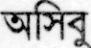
অসিবু
